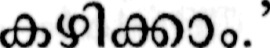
കഴിക്കാം.’
